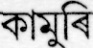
কামুৰি
